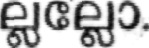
ല്ലല്ലോ.
